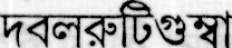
দবলরুটিগুম্বা
